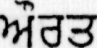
ਔਰਤ
